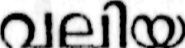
വലിയ
